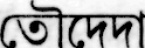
তৌদেদা
